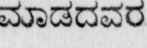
ಮಾಡದವರ
